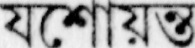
যশোয়ন্ত
